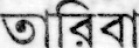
তারিবা
